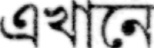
এখানে
